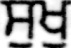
ਸੁਖੁ
